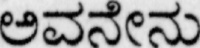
ಅವನೇನು
